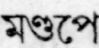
মণ্ডপে
